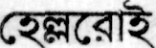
হেল্লরোই
